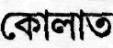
কোলাত
